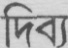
দিব্য
